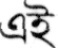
এই
